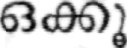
ഒക്കൂ
